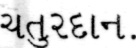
ચતુરદાન.
